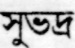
সুভদ্র
